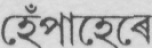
হেঁপাহেৰে
